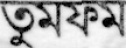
তুমফম
